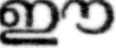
ഈ
